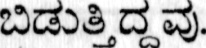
ಬಿಡುತ್ತಿದ್ದವು.
